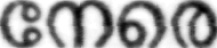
നേരെ
